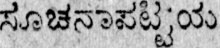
ಸೂಚನಾಪಟ್ಟಿಯ
